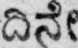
ದಿನೇ
